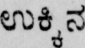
ಉಕ್ಕಿನ
